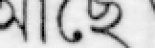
আছে
